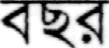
বছর
